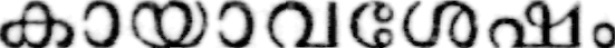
കായാവശേഷം
